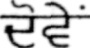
ਦੋਵੇਂ
